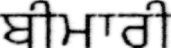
ਬੀਮਾਰੀ
